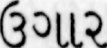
ઉગાર
